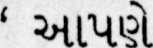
'આપણે
